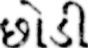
છોડી
